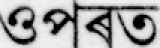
ওপৰত
